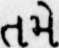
તમે
